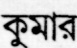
কুমার
